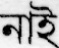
নাই
